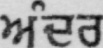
ਅੰਦਰ
